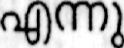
എന്നു
